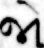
જો
